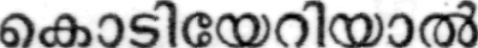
കൊടിയേറിയാല്‍
